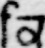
ਕਿ
